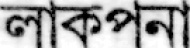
লাকপনা
